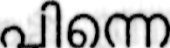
പിന്നെ
